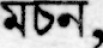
মচন,
